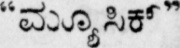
“ಮ್ಯೂಸಿಕ್”
